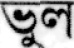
ভুল
